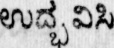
ಉದ್ಭವಿಸಿ
